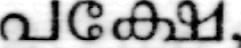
പക്ഷേ,
